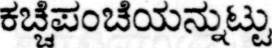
ಕಚ್ಚೆಪಂಚೆಯನ್ನುಟ್ಟು
